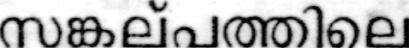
സങ്കല്പത്തിലെ
